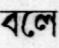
বলে
